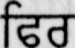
ਫਿਰ
